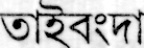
তাইবংদা
